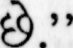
છે."
